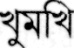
খুমখি
